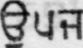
ਉਪਜ
